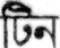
টিন
